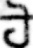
ਹੋ
